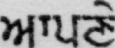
ਆਪਣੇ
